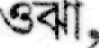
ওঝা,
